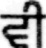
ਵੀ
